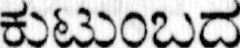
ಕುಟುಂಬದ
